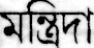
মন্ত্রিদা
